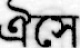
ঐসে
